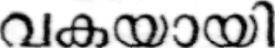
വകയായി
